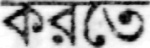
করতে
